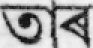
তাৰ
